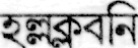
হল্লক্লবনি
